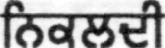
ਨਿਕਲਦੀ
